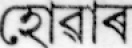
হোৱাৰ
